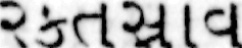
રક્તસ્રાવ
